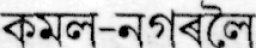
কমল-নগৰলৈ
